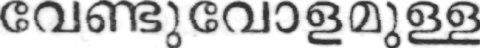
വേണ്ടുവോളമുള്ള
